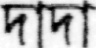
দাদা
